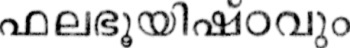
ഫലഭൂയിഷ്ഠവും
